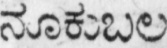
ನೂಕುಬಲ
